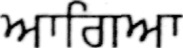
ਆਗਿਆ
